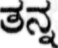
ತನ್ನ
